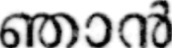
ഞാന്‍
